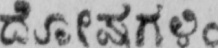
ದೋಷಗಳಿಂ
